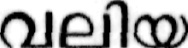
വലിയ
